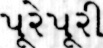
પૂરેપૂરી
